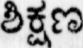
ಶಿಕ್ಷಣ
